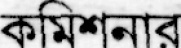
কমিশনার
